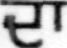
ਦਾ
